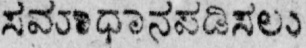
ಸಮಾಧಾನಪಡಿಸಲು
